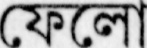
ফেলো
